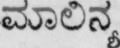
ಮಾಲಿನ್ಯ
